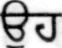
ਉਹ
